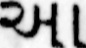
આ
